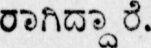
ರಾಗಿದ್ದಾರೆ.
